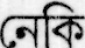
নেকি
